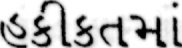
હકીકતમાં
